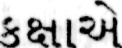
કક્ષાએ
